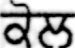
ਕੋਲ
